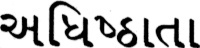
અધિષ્ઠાતા
